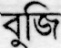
বুজি
